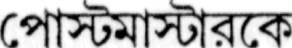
পোস্টমাস্টারকে
